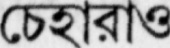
চেহারাও
